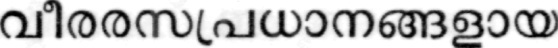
വീരരസപ്രധാനങ്ങളായ
